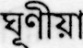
ঘূণীয়া
